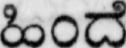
ಹಿಂದೆ
